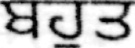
ਬਹੁਤ
